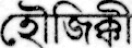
হৌজিক্কী
